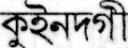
কুইনদগী
